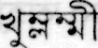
খুম্লম্মী
